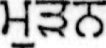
ਮੁੜਨ
